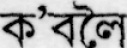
ক'বলৈ
